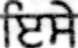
ਇਸੇ
